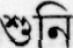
শুনি
